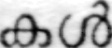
കള്‍
